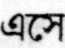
এসে
